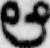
ಆ
